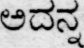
ಅದನ್ನ
